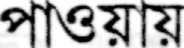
পাওয়ায়
